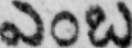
ಎಂಬ
